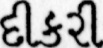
દીકરી
